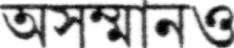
অসম্মানও
